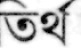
তির্থ
